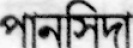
পানসিদা
